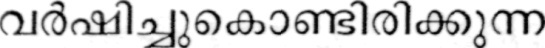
വര്‍ഷിച്ചുകൊണ്ടിരിക്കുന്ന
